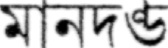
মানদণ্ড
